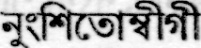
নুংশিতোম্বীগী
